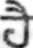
ਹੈ
